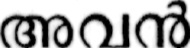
അവന്‍
